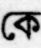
কে
